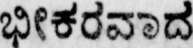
ಭೀಕರವಾದ
